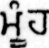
ਮੂੰਹ
